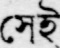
সেই
